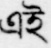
এই
